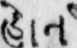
હોન
